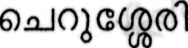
ചെറുശ്ശേരി
